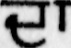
ਦਾ
